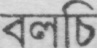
বলচি
